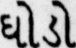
ઘોડો
